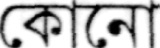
কোনো
